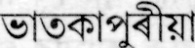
ভাতকাপুৰীয়া
